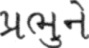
પ્રભુને
